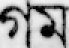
গম
